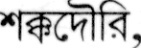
শক্কদৌরি,
